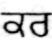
ਕਰ
